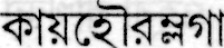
কায়হৌরম্লগা
